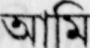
আমি
